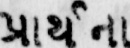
પ્રાર્થના
